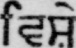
ਵਿਸ਼ੇ
